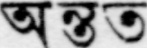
অন্তত
